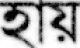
হায়
